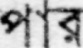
পার
